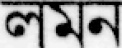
লমন
